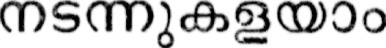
നടന്നുകളയാം
